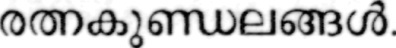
രത്നകുണ്ഡലങ്ങള്‍.
